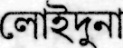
লোইদুনা
